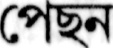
পেছন
